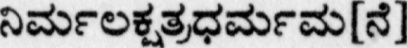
ನಿರ್ಮಲಕ್ಷತ್ರಧರ್ಮಮ[ನೆ)
